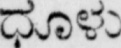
ಧೂಳು
